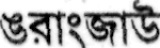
ঙরাংজাউ
